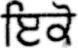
ਇਕੋ
